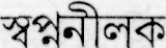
স্বপ্ননীলক
